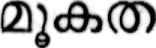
മൂകത
